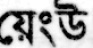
য়েংউ
